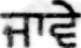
ਜਾਵੇ
